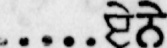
..........ਏਨੇ
